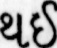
થઈ
